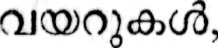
വയറുകള്‍,
